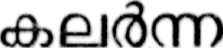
കലര്‍ന്ന
